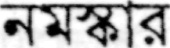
নমস্কার
